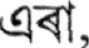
এৰা,
